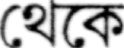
থেকে
